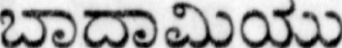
ಬಾದಾಮಿಯು
